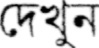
দেখুন
